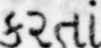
કરતાં
